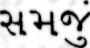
સમજું
